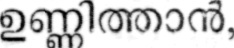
ഉണ്ണിത്താന്‍,
